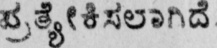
ಪ್ರತ್ಯೇಕಿಸಲಾಗಿದೆ.
